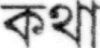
কথা
